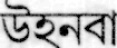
উহনবা
